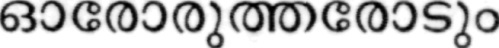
ഓരോരുത്തരോടും
